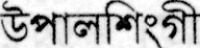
উপালশিংগী
